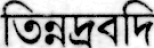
তিন্নদ্রবদি
